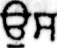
ਉਸ
